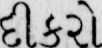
દીકરો
